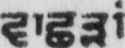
ਵਾਛੜਾਂ
